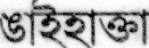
ঙাইহাক্তা
